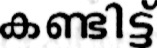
കണ്ടിട്ട്
